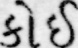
કોઈ
